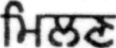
ਮਿਲਣ
